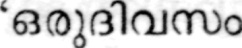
‘ഒരുദിവസം
